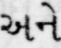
અને
